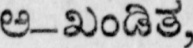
ಅ-ಖಂಡಿತ,
